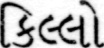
કિલ્લો
